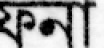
ফনা
